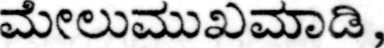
ಮೇಲುಮುಖಮಾಡಿ,
